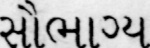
સૌભાગ્ય
